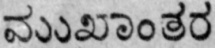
ಮುಖಾಂತರ
